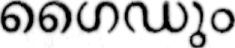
ഗൈഡും
